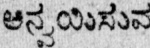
ಅನ್ವಯಿಸುವ
